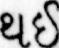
થઈ
